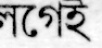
লগেই
